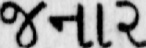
જનાર
